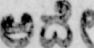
ಅದೇ
